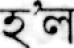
হ'ল
